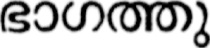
ഭാഗത്തു
